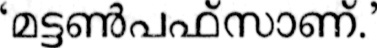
‘മട്ടണ്‍പഫ്സാണ്.’
